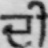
ਦੀ
